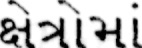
ક્ષેત્રોમાં
